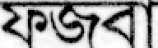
ফজবা
